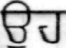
ਉਹ
